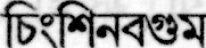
চিংশিনবগুম
